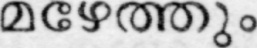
മഴേത്തും
